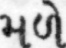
મળે
